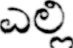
ಎಲ್ಲಿ
